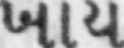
ખાય
